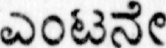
ಎಂಟನೇ
